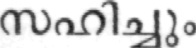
സഹിച്ചും
